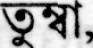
তুম্বা,
